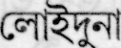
লোইদুনা
